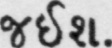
જઈશ.
